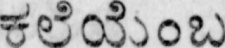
ಕಲೆಯೆಂಬ
